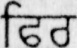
ਫਿਰ
